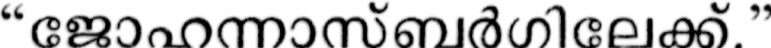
“ജോഹന്നാസ്ബര്‍ഗിലേക്ക്.”
